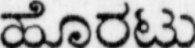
ಹೊರಟು
